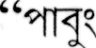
“পাবুং
